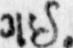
ગઈ.
